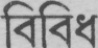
বিবিধ
